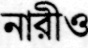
নারীও
